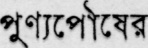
পুণ্যপৌষের
